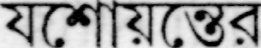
যশোয়ন্তের
